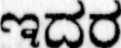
ಇದರ
